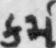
કર્મ
